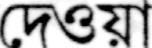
দেওয়া
